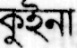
কুইনা
